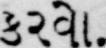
કરવો.
